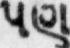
પણ
